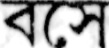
বসে
